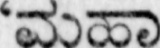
‘ಮಹಾ
